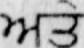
ਅਤੇ
